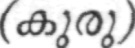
(കുരു)
